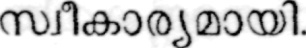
സ്വീകാര്യമായി.
